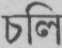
চলি
